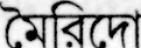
মৈরিদো
